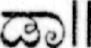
ಡಾ||
